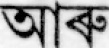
আৰু
